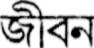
জীবন
